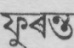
ফুৰন্ত
